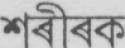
শৰীৰক
